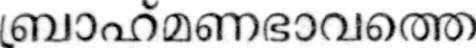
ബ്രാഹ്മണഭാവത്തെ
